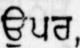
ਉਪਰ,
